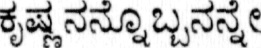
ಕೃಷ್ಣನನ್ನೊಬ್ಬನನ್ನೇ
